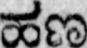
ಹಣ
